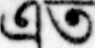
এত
